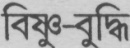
বিষ্ণু-বুদ্ধি
